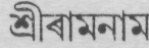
শ্ৰীৰামনাম
